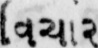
વિચાર
